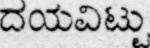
ದಯವಿಟ್ಟು
